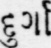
દુર્ગા
